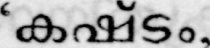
'കഷ്ടം,
